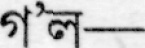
গ'ল-
